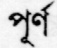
পূর্ণ
